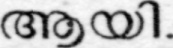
ആയി.
